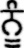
ਨੂੰ
